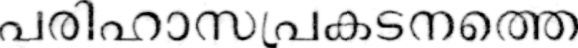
പരിഹാസപ്രകടനത്തെ
